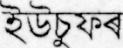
ইউচুফৰ
